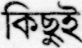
কিছুই
